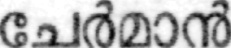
ചേര്‍മാന്‍
